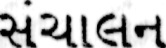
સંચાલન
